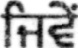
ਜਿਵੇਂ
